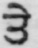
ਤੇ
